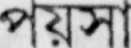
পয়সা
